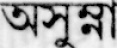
অসুম্না
